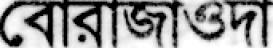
বোরাজাওদা
